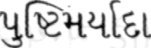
પુષ્ટિમર્યાદા
